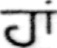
ਹਾਂ
